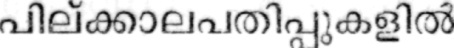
പില്ക്കാലപതിപ്പുകളില്‍
